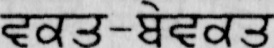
ਵਕਤ-ਬੇਵਕਤ
